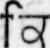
ਕਿ
